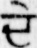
ਦੇ
